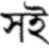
সই
